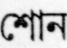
শোন
